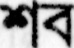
শব
